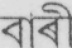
বাৰী
